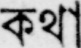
কথা
